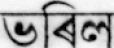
ভৰিল
